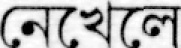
নেখেলে
